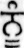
ਨੂੰ
